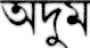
অদুম
